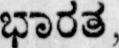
ಭಾರತ,
